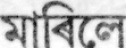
মাৰিলে
